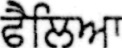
ਫੈਲਿਆ
